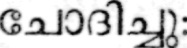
ചോദിച്ചു:
